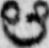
ಆ
